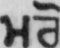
ਮਰੋ
